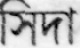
সিদা
